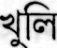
খুলি
